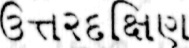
ઉત્તરદક્ષિણ
